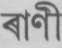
ৰাণী
